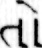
તો
